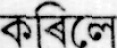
কৰিলে
